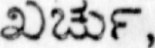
ಖರ್ಚು,
